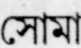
সোমা
